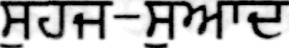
ਸੁਹਜ-ਸੁਆਦ
